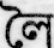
লৈ
